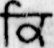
ਕਿ
